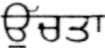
ਉੱਚਤਾ
